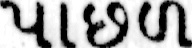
પાછળ
